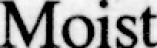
Moist
